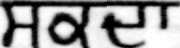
ਸਕਦਾ
